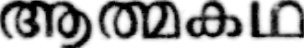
ആത്മകഥ
